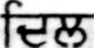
ਦਿਲ
